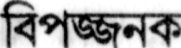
বিপজ্জনক
